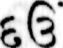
દઉં
